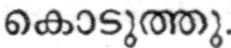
കൊടുത്തു.
